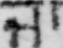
ਜਾ
